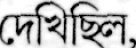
দেখিছিল,
